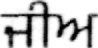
ਜੀਅ
